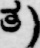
ತ)
